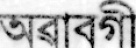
অৱাবগী
